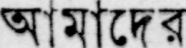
আমাদের
